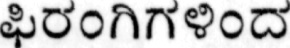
ಫಿರಂಗಿಗಳಿಂದ
